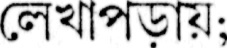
লেখাপড়ায়;
